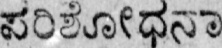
ಪರಿಶೋಧನಾ
